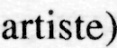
artiste)
